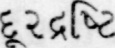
દૂરદ્રષ્ટિ
